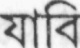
যাবি
